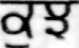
ਕੁਝ
